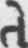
તે
